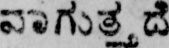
ವಾಗುತ್ತದೆ
